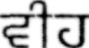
ਵੀਹ
